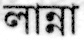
লান্না
